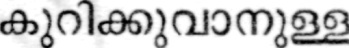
കുറിക്കുവാനുള്ള
